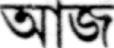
আজ
